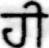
ਹੀ
